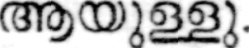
ആയുള്ളു.
